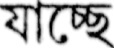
যাচ্ছে
